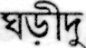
ঘড়ীদু
